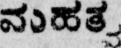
ಮಹತ್ವ
